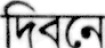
দিবনে
